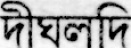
দীঘলদি
